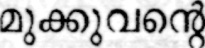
മുക്കുവന്റെ
